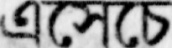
এসেচে
